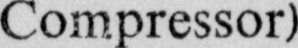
Compressor)
